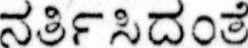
ನರ್ತಿಸಿದಂತೆ
